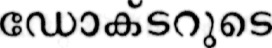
ഡോക്ടറുടെ
